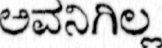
ಅವನಿಗಿಲ್ಲ
